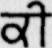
ਕੀ
